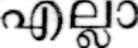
എല്ലാ
